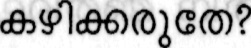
കഴിക്കരുതേ?
